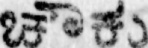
ಚೌಕು
